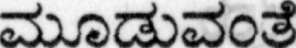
ಮೂಡುವಂತೆ
